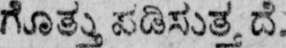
ಗೊತ್ತುಪಡಿಸುತ್ತದೆ.
